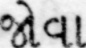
જોવા
